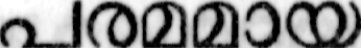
പരമമായ
